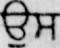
ਉਸ
